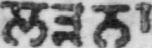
ਲੜਨਾ
